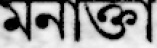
মনাক্তা
